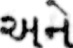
અને
